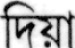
দিয়া
